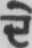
ਦੇ
